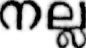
നല്ല
